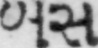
બસ
